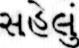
સહેલું
